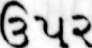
ઉપર
